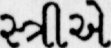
સ્ત્રીએ
